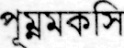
পূম্নমকসি
